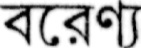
বরেণ্য
